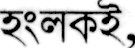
হংলকই,
